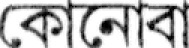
কোনোবা
